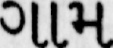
ગામ
